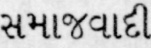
સમાજવાદી
